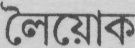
লৈয়োক
